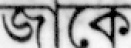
জাকে
